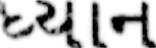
ધ્યાન
